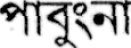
পাবুংনা
